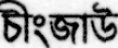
চীংজাউ
